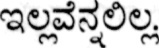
ಇಲ್ಲವೆನ್ನಲಿಲ್ಲ.
